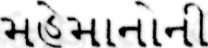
મહેમાનોની
